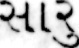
સારુ
